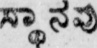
ಸ್ಥಾನವು
